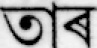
তাৰ
